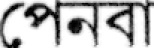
পেনবা
